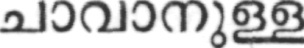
ചാവാനുള്ള
